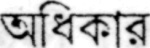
অধিকার
